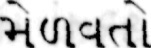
મેળવતો
